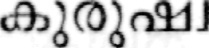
കുരുഷ്വ
